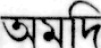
অমদি
